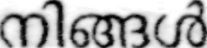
നിങ്ങള്‍
